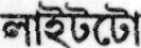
লাইটটো
